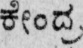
ಕೇಂದ್ರ
